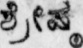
ಶ್ರೇಷ್ಠ
